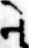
ને
